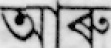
আৰু
